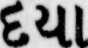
દયા
